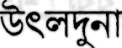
উৎলদুনা
